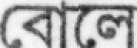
বোলে
